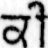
ਕੀ
